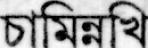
চামিন্নখি
